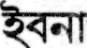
ইবনা
